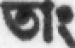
তাং
